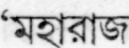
‘মহারাজ
